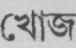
খোজ
